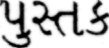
પુસ્તક
